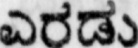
ಎರಡು
